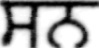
ਸਨ
